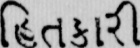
હિતકારી
